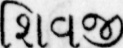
શિવજી
